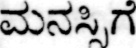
ಮನಸ್ಸಿಗೆ
